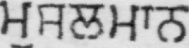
ਮੁਸਲਮਾਨ
